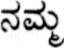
ನಮ್ಮ
